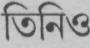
তিনিও
